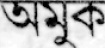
অমুক
